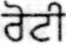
ਰੋਟੀ
